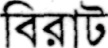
বিরাট
